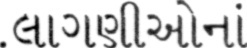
લાગણીઓનાં
